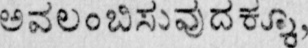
ಅವಲಂಬಿಸುವುದಕ್ಕೂ,
